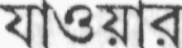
যাওয়ার
